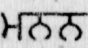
ਮਨਨ
